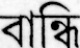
বান্ধি
